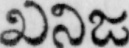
ಖನಿಜ
